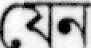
যেন
